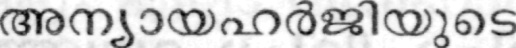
അന്യായഹര്‍ജിയുടെ
